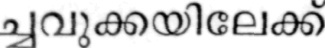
ച്ചവുക്കയിലേക്ക്
